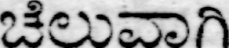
ಚೆಲುವಾಗಿ
